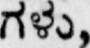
ಗಳು,
